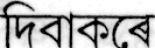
দিবাকৰে
